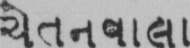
ચેતનવાલા
